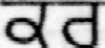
ਕਰ
